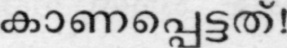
കാണപ്പെട്ടത്!
